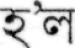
হ'ল
